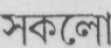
সকলো
